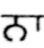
ਨਾ
